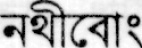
নথীবোং
